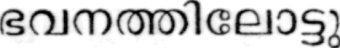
ഭവനത്തിലോട്ടു
